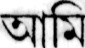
আমি
